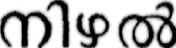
നിഴല്‍
